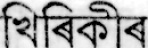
খিৰিকীৰ
